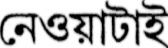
নেওয়াটাই
